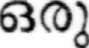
ഒരു
